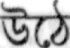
উঠে
